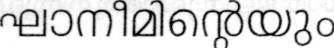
ഘാനീമിന്റെയും
